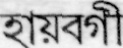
হায়বগী
